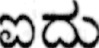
ಐದು
